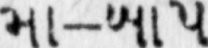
મા-બાપ
